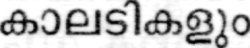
കാലടികളും
